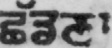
ਛੱਡਣਾ
